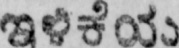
ಇಳಿಕೆಯ
